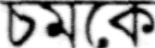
চমকে
